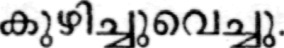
കുഴിച്ചുവെച്ചു.
